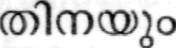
തിനയും
